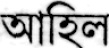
আহিল
